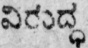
ವಿರುದ್ಧ
